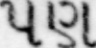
પણ
